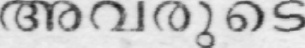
അവരുടെ
